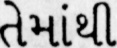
તેમાંથી
